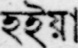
হইয়া
